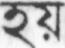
হয়
